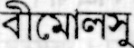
বীমোলসু
